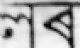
স্কুলৰ
